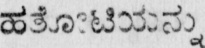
ಹತೋಟಿಯನ್ನು
